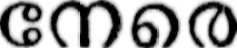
നേരെ
